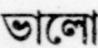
ভালো
